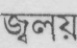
জ্বলয়
